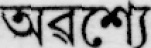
অৱশ্যে
